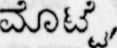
ಮೊಟ್ಟೆ,
